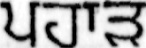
ਪਹਾੜ
